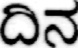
ದಿನ
